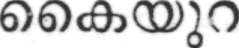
കൈയുറ
